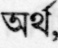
অর্থ,
